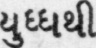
યુધ્ધથી
